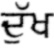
ਦੁੱਖ
